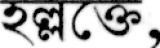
হল্লক্তে,
